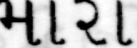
મારા
